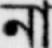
না
